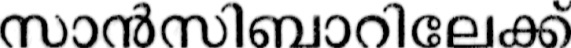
സാന്‍സിബാറിലേക്ക്
